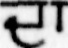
ਦਾ
